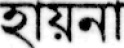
হায়না
